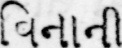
વિનાની
